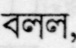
বলল,
